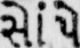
સોંપે
